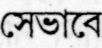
সেভাবে
